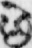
છે
